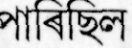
পাৰিছিল
